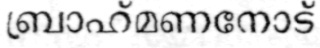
ബ്രാഹ്മണനോട്
